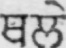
ਥਲੇ
